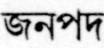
জনপদ
